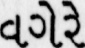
વગેરે
